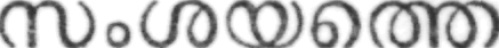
സംശയത്തെ
